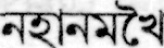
নহানমখৈ
